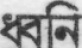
ধ্বনি
